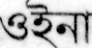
ওইনা
